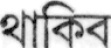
থাকিব
